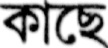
কাছে
